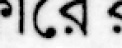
ফারে
